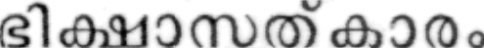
ഭിക്ഷാസത്കാരം
